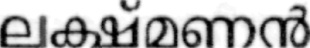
ലക്ഷ്മണന്‍
